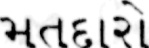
મતદારો
